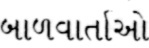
બાળવાર્તાઓ
